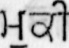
ਮੁਕੀ
